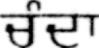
ਚੰਦਾ
